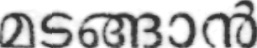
മടങ്ങാന്‍
